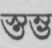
স্তম্ভ
